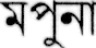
মপুনা
